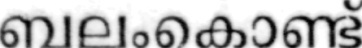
ബലംകൊണ്ട്
